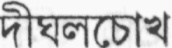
দীঘলচোখ
